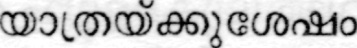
യാത്രയ്ക്കുശേഷം
